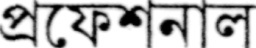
প্রফেশনাল
